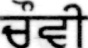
ਚੌਵੀ
